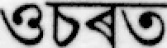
ওচৰত
